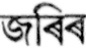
জৰিৰ
